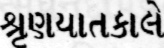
શ્રૃણયાતકાલે
